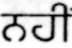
ਨਹੀਂ
